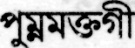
পুম্নমক্তগী
